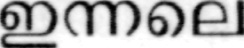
ഇന്നലെ
